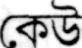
কেউ
